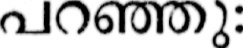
പറഞ്ഞു:
